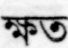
ক্ষত
